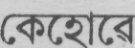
কেহোৱে
